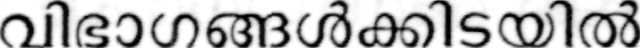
വിഭാഗങ്ങള്‍ക്കിടയില്‍
